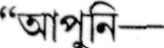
"আপুনি-
